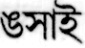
ঙসাই
